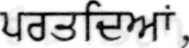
ਪਰਤਦਿਆਂ,
